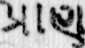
પ્રાણ
